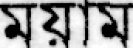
ময়াম
